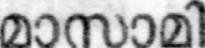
മാസാമി
